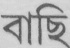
বাছি
